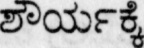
ಶೌರ್ಯಕ್ಕೆ
